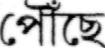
পৌঁছে
